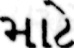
માટે
